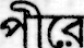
পীরে
